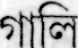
গালি
